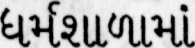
ધર્મશાળામાં
